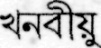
খনবীয়ু
